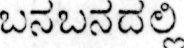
ಬನಬನದಲ್ಲಿ
